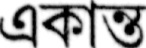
একান্ত
